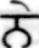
ਨੇ
